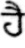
ਹੈ
